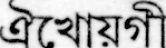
ঐখোয়গী
